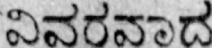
ವಿವರವಾದ
